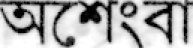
অশেংবা
